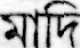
মাদি
